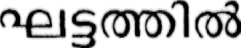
ഘട്ടത്തില്‍
